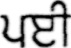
ਪਈ
